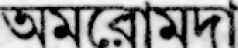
অমরোমদা
